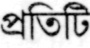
প্রতিটি
